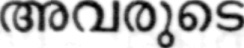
അവരുടെ
